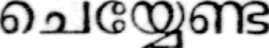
ചെയ്യേണ്ട
